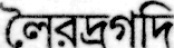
লৈরদ্রগদি
